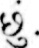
છું.
